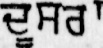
ਦੂਸਰਾ
